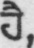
ਹੈ,
